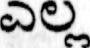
ಎಲ್ಲ
